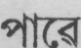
পাৱে
